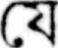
যে
